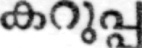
കറുപ്പ
